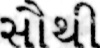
સૌથી
